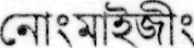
নোংমাইজীং
